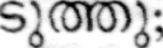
ടുത്തു;
